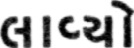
લાવ્યો
